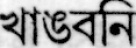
খাঙবনি
